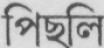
পিছলি
